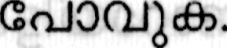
പോവുക.
